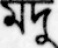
মদু
